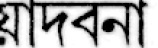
য়াদবনা
